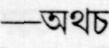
–অথচ
